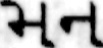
મન
